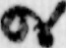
જ
